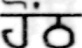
ਹੋਂਠ
